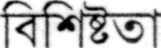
বিশিষ্টতা
